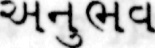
અનુભવ
